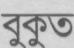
বুকুত
